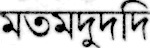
মতমদুদদি
